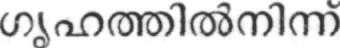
ഗൃഹത്തില്‍നിന്ന്
